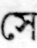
সে
